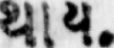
થાય.
